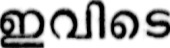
ഇവിടെ
